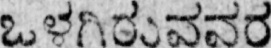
ಒಳಗಿರುವವರ
